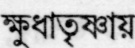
ক্ষুধাতৃষ্ণায়
